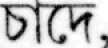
চাদে,
